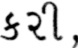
કરી,
